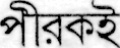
পীরকই
